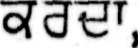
ਕਰਦਾ,
